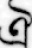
ঐ
